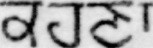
ਕਹਣਾ
